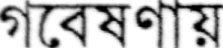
গবেষণায়
